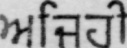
ਅਜਿਹੀ
